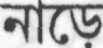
নাড়ে
